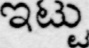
ಇಟ್ಟು
